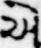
એ
